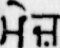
ਮੇਜ਼
